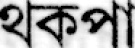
থকপা
